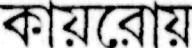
কায়রোয়
